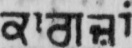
ਕਾਗਜ਼ਾਂ
